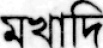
মখাদি
